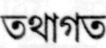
তথাগত
